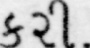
કરી.
